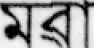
মৱা
